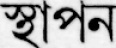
স্থাপন
